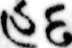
હદ
